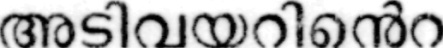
അടിവയറിന്റെ
